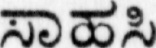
ಸಾಹಸಿ
